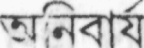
অনিবার্য
